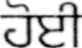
ਹੋਈ
